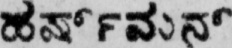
ಹರ್ಷಮನ್
